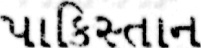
પાકિસ્તાન
